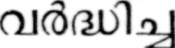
വര്‍ദ്ധിച്ച
